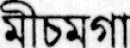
মীচমগা
